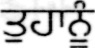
ਤੁਹਾਨੂੰ
